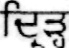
ਦ੍ਰਿੜ੍ਹ
